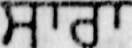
ਸਾਰਾ
